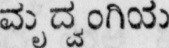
ಮೃದ್ವಂಗಿಯ
